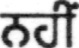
ਨਹੀਂ
